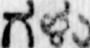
ಗಳು
